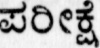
ಪರೀಕ್ಷೆ
